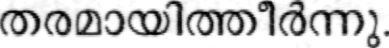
തരമായിത്തീര്‍ന്നു.
